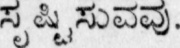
ಸೃಷ್ಟಿಸುವವು.
